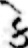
કે
